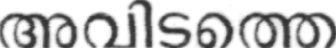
അവിടത്തെ
